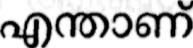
എന്താണ്
